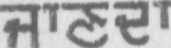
ਜਾਣਦਾ
